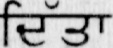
ਦਿੱਤਾ
